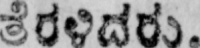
ತೆರಳಿದರು.
